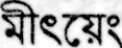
মীৎয়েং
